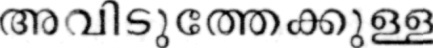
അവിടുത്തേക്കുള്ള
